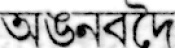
অঙনবদৈ
